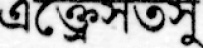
এক্ত্রেসতসু
